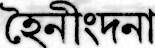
হৈনীংদনা
